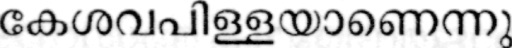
കേശവപിള്ളയാണെന്നു
